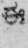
ಈ
